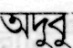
অদুবু
